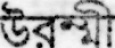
উরম্মী
